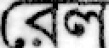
রেল
